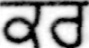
ਕਰ
